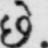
છે.
